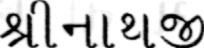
શ્રીનાથજી
